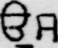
ਉਸ
